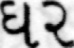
ઘર
